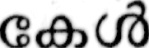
കേള്‍
